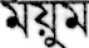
ময়ুম
